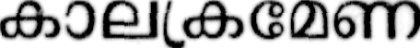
കാലക്രമേണ
